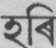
হৰি
